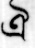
ঐ
